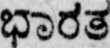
ಭಾರತ
